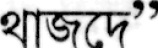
থাজদে”
